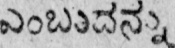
ಎಂಬುದನ್ನು
